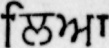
ਲਿਆ
